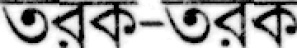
তরক-তরক
